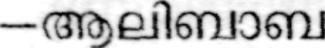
-ആലിബാബ
